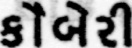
કોબેરી
